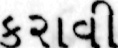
કરાવી
